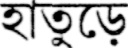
হাতুড়ে
